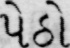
પેઠો
